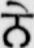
ਨੇ
